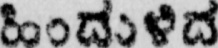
ಹಿಂದುಳಿದ
